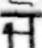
ਜੋ
